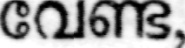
വേണ്ട,
